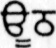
ਊਠ
